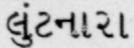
લુંટનારા
